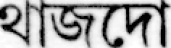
থাজদো
